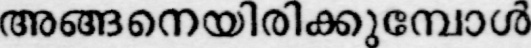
അങ്ങനെയിരിക്കുമ്പോള്‍
